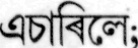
এচাৰিলে;
